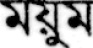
ময়ুম
